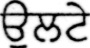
ਉਲਟੇ
